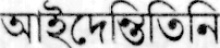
আইদেন্তিতিনি
